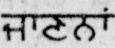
ਜਾਣਨਾਂ
